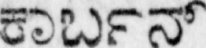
ಕಾರ್ಬ್‌ನ್
